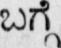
ಬಗ್ಗೆ
